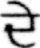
ਦੇ
